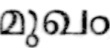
മുഖം
